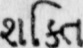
શક્તિ
